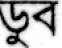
ডুব
